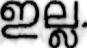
ഇല്ല.
